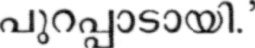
പുറപ്പാടായി.'
